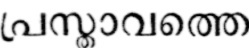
പ്രസ്താവത്തെ
